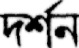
দর্শন
